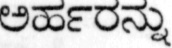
ಅರ್ಹರನ್ನು
